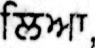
ਲਿਆ,
